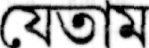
যেতাম
